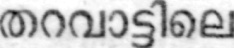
തറവാട്ടിലെ
